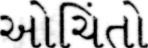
ઓચિંતો
